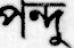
পন্দু
